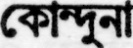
কোন্দুনা
